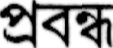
প্রবন্ধ
